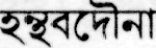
হন্থবদৌনা
